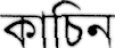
কাচিন
